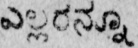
ಎಲ್ಲರನ್ನೂ
